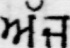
ਅੱਜ
